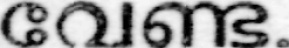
വേണ്ട.
